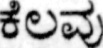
ಕೆಲವು
